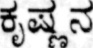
ಕೃಷ್ಣನ
